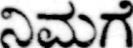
ನಿಮಗೆ
